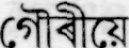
গৌৰীয়ে
